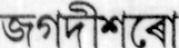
জগদীশৰো
